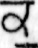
ਕੁ
